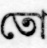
তো
